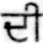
ਦੀ
